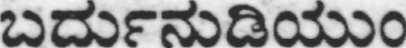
ಬರ್ದುನುಡಿಯುಂ
